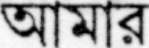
আমার
